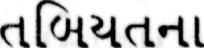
તબિયતના
